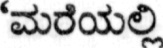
‘ಮರೆಯಲ್ಲಿ
